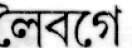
লৈবগে
